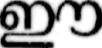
ഈ
